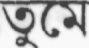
তুমে
